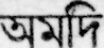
অমদি
